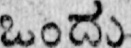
ಒಂದು
